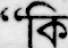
"কি
